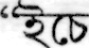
“ইচে
